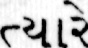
ત્યારે
